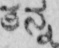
ತನ್ನ
